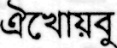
ঐখোয়বু
